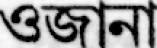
ওজানা
